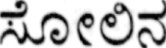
ಸೋಲಿನ
